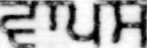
ਵਾਪਸ
